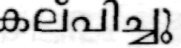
കല്പിച്ചു
